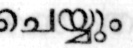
ചെയ്യും
